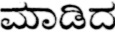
ಮಾಡಿದ
